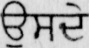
ਉਸਦੇ
